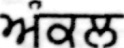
ਅੰਕਲ
